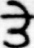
ਤੇ
